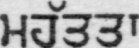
ਮਹੱਤਤਾ
